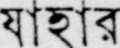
যাহার
